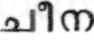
ചീന
